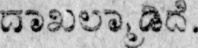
ದಾಖಲ್ಮಾಡಿದೆ.
